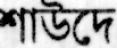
শাউদে
